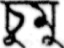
চুমু
